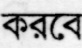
করবে
